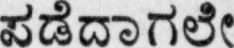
ಪಡೆದಾಗಲೇ
